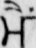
ਮੈਂ
